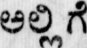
ಅಲ್ಲಿಗೆ
